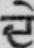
ਦੇ
